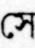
সে
